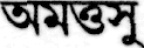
অমত্তসু
